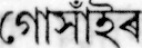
গোসাঁইৰ
